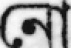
নো
